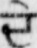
ਦੇ
